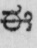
ಈ
